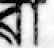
ৱা
